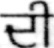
ਦੀ
